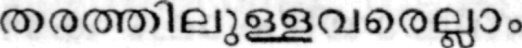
തരത്തിലുള്ളവരെല്ലാം
